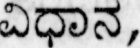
ವಿಧಾನ,
